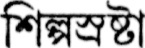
শিল্পস্রষ্টা
